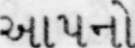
આપનો
